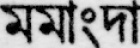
মমাংদা
